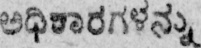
ಅಧಿಕಾರಗಳನ್ನು
